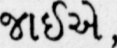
જોઈએ,
